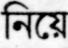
নিয়ে
